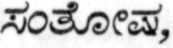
ಸಂತೋಷ,
